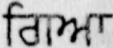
ਗਿਆ
